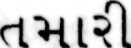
તમારી
